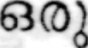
ഒരു
